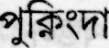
পুক্নিংদা
